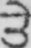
ਤੇ
